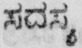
ಸದಸ್ಯ
